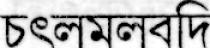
চৎলমলবদি
